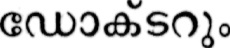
ഡോക്ടറും
